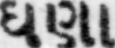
ઘણા
